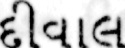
દીવાલ
